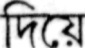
দিয়ে
